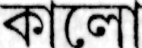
কালো
